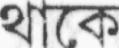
থাকে
